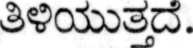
ತಿಳಿಯುತ್ತದೆ.
